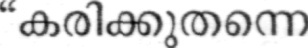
“കരിക്കുതന്നെ
